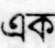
এক
